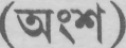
(অংশ)
